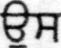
ਉਸ
